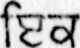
ਇਕ
